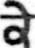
ਕੇ
